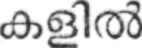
കളില്‍
